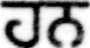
ਹਨ
